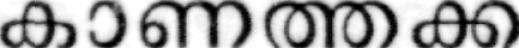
കാണത്തക്ക
